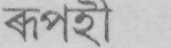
ৰূপহী
